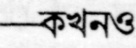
–কখনও
